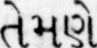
તેમણે
